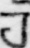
ਹੋ
